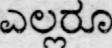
ಎಲ್ಲರೂ
